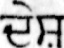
ਦੇਸ਼
